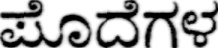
ಪೊದೆಗಳ
